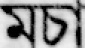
মচা
